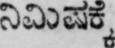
ನಿಮಿಷಕ್ಕೆ
